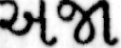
અજા
